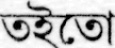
তইতো
